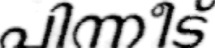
പിന്നീട്
